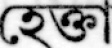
হেক্তা
